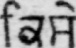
ਕਿਸੇ
